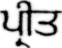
ਪ੍ਰੀਤ
